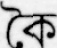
কৈ
